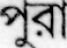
পুরা
